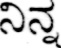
ನಿನ್ನ
